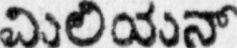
ಮಿಲಿಯನ್
